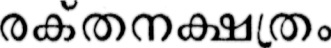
രക്തനക്ഷത്രം
